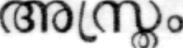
അസ്ത്രം
